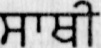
ਸਾਥੀ
